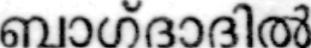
ബാഗ്ദാദില്‍
